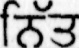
ਨਿੱਤ
